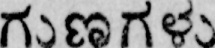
ಗುಣಗಳು
